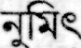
নুমিৎ
